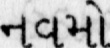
નવમો
